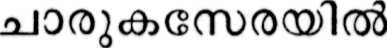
ചാരുകസേരയില്‍
